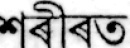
শৰীৰত
